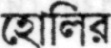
হোলির
